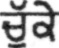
ਚੁੱਕੇ
